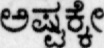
ಅಷ್ಟಕ್ಕೇ
